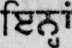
ਇਨ੍ਹਾਂ
